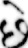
છે
